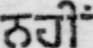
ਨਹੀਂ
